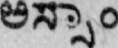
ಅಸ್ಸಾಂ
